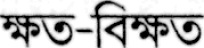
ক্ষত-বিক্ষত
